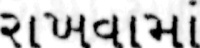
રાખવામાં
